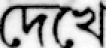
দেখে
